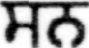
ਸਨ
